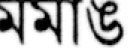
মমাঙ
